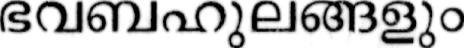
ഭവബഹുലങ്ങളും
